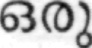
ഒരു
